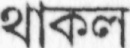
থাকল
